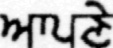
ਆਪਣੇ
